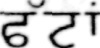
ਫੱਟਾਂ
